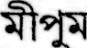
মীপুম
